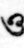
ও
